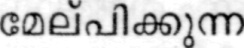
മേല്പിക്കുന്ന
